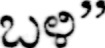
ಬಳಿ"
